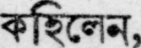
কহিলেন,
